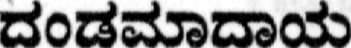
ದಂಡಮಾದಾಯ
